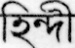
হিন্দী
